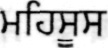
ਮਹਿਸੂਸ
